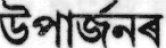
উপার্জনৰ
